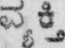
ವ್ಯಕ್ತಿ
